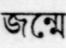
জন্মে
